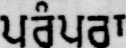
ਪਰੰਪਰਾ
